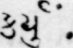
કર્યું.
